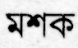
মশক
